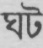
ঘট
